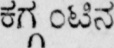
ಕಗ್ಗಂಟಿನ
